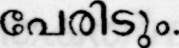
പേരിടും.
